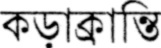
কড়াক্রান্তি
